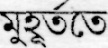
মুহূর্ততে
